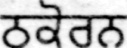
ਠਕੋਰਨ
